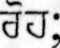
ਰੋਹ;
